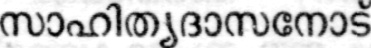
സാഹിത്യദാസനോട്
